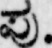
ಪು.
